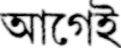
আগেই
